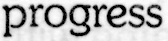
progress
